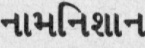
નામનિશાન
